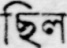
ছিল
